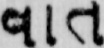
વાત
